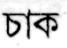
চাক
